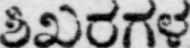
ಶಿಖರಗಳ
